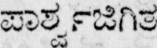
ಪಾರ್ಶ್ವಜಿಗಿತ
